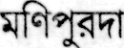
মণিপুরদা
